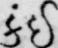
કંઈ
